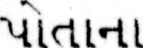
પોતાના
